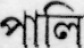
পালি
